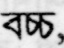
বচ্চ,
